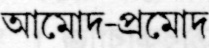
আমোদ-প্রমোদ
